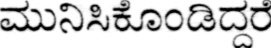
ಮುನಿಸಿಕೊಂಡಿದ್ದರೆ
